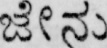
ಜೇನು
